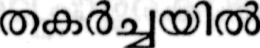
തകര്‍ച്ചയില്‍
